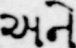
અને
